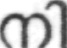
നി
